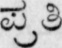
ಪ್ರತಿ
